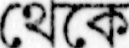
থেকে
